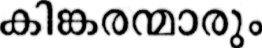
കിങ്കരന്മാരും
